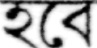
হবে
